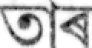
তাৰ
